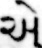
એ
